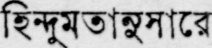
হিন্দুমতানুসারে
